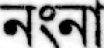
নংনা
